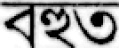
বহুত
